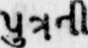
પુત્રની
